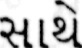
સાથે
